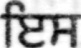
ਇਸ
